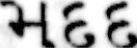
મદદ
